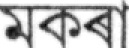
মকৰা
